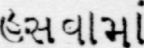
હસવામાં
